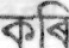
কৰি
